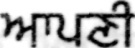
ਆਪਣੀ
